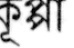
কূপ্পা
